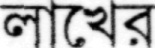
লাখের
